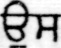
ਉਸ
